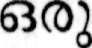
ഒരു
